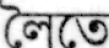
লৈতে
